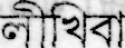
লীখিবা
